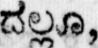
ದಲ್ಲೂ,
